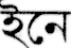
ইনে
